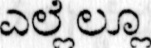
ಎಲ್ಲೆಲ್ಲೂ
